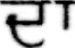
ਦਾ
